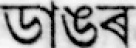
ডাঙৰ
